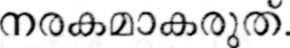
നരകമാകരുത്.
